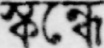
স্কন্ধে
